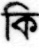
কি
